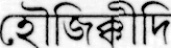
হৌজিক্কীদি
